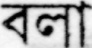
বলা
